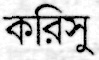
করিসু
